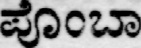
ಪೊಂಬಾ
